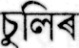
চুলিৰ
